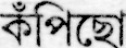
কঁপিছো
